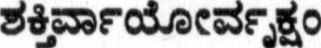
ಶಕ್ತಿರ್ವಾಯೋರ್ವೃಕ್ಷಂ
